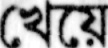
খেয়ে
